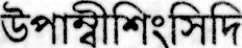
উপাম্বীশিংসিদি
